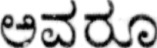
ಅವರೂ
